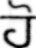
ਹੋ
